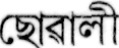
ছোৱালী
